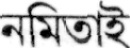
নমিতাই
